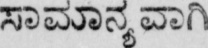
ಸಾಮಾನ್ಯವಾಗಿ
